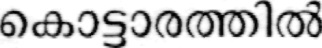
കൊട്ടാരത്തില്‍
